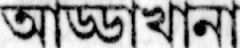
আড্ডাখানা
